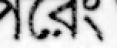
পরেং
